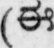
(ಈ
